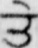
ਤੇ
